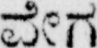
ವೇಗ
